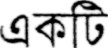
একটি
